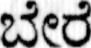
ಬೇರೆ
